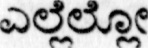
ಎಲ್ಲೆಲ್ಲೋ
